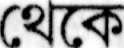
থেকে
